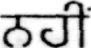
ਨਹੀਂ
